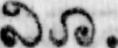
ಮೀ.
